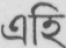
এহি
